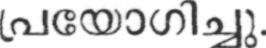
പ്രയോഗിച്ചു.
